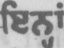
ਇਨ੍ਹਾਂ
